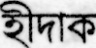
হীদাক
